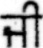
ਜੀ
